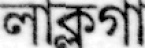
লাক্লগা
